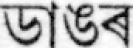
ডাঙৰ
